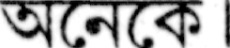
অনেকে।
